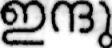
ഇന്ദു
